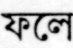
ফলে
